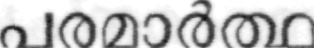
പരമാര്‍ത്ഥ
